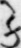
કે
